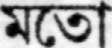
মতো
